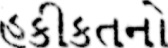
હકીકતનો
